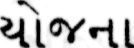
યોજના
